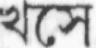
খসে
